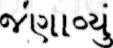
જણાવ્યું
